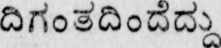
ದಿಗಂತದಿಂದೆದ್ದು
